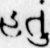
હતું
